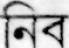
নিব
